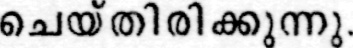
ചെയ്തിരിക്കുന്നു.
